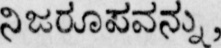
ನಿಜರೂಪವನ್ನು,
